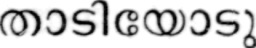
താടിയോടു
